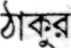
ঠাকুর
